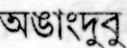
অঙাংদুবু
